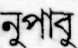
নুপাবু
